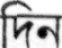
দিন
